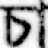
চা
